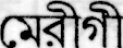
মেরীগী
